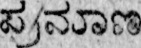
ಪ್ರಮಾಣ
